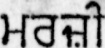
ਮਰਜ਼ੀ
